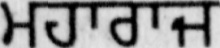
ਮਹਾਰਾਜ
